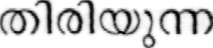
തിരിയുന്ന
